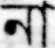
না
